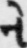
ને
